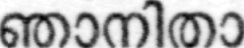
ഞാനിതാ
